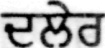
ਦਲੇਰ
